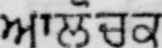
ਆਲੋਚਕ
